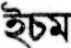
ইচম
